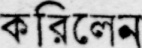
করিলেন
